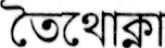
তৈথোক্না
